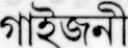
গাইজনী
